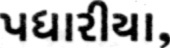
પધારીયા,
